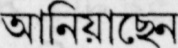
আনিয়াছেন
